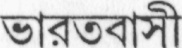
ভারতবাসী
